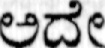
ಅದೇ
